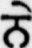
ਨੇ
